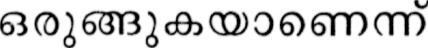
ഒരുങ്ങുകയാണെന്ന്
